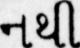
નથી
